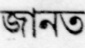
জানত
